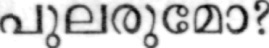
പുലരുമോ?
